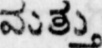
ಮತ್ತು
